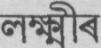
লক্ষ্মীৰ
